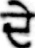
ਦੇ
